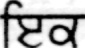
ਇਕ
